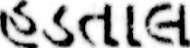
હડતાલ
